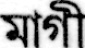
মাগী
